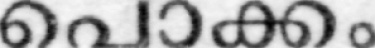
പൊക്കം
